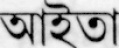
আইতা
